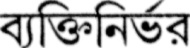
ব্যক্তিনির্ভর
